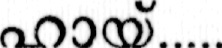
ഹായ്.....
